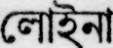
লোইনা
